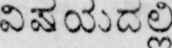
ವಿಷಯದಲ್ಲಿ
